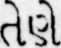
તેણે
